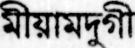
মীয়ামদুগী
